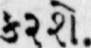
કરશે.
